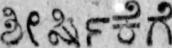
ಶೀರ್ಷಿಕೆಗೆ
